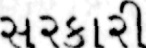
સરકારી
